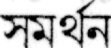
সমর্থন
